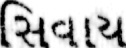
સિવાય
